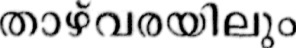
താഴ്വരയിലും
